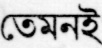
তেমনই
